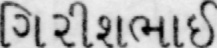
ગિરીશભાઈ
